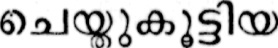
ചെയ്തുകൂട്ടിയ
